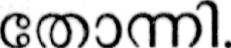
തോന്നി.
